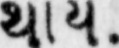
થાય.
